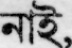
নাই,
